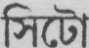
সিটো
